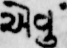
એવું
